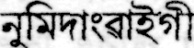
নুমিদাংৱাইগী
